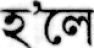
হ'লে
